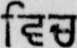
ਵਿਚ
